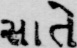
સાતે
